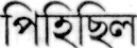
পিহিছিল
